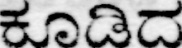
ಕೂಡಿದ
